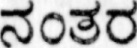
ನಂತರ
